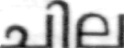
ചില
